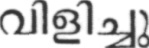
വിളിച്ചു
